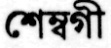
শেম্বগী
